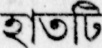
হাতটি
